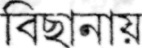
বিছানায়
